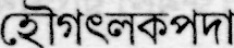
হৌগৎলকপদা
